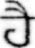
ਹੈ
